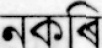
নকৰি
